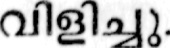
വിളിച്ചു.
